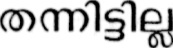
തന്നിട്ടില്ല
